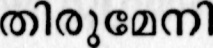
തിരുമേനി
